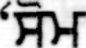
'ਸੋਮ
